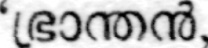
‘ഭ്രാന്തന്‍,
